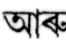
আৰু
